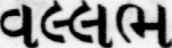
વલ્લભ
